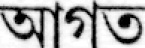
আগত
